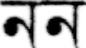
নন
